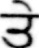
ਤੇ
